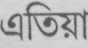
এতিয়া
